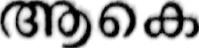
ആകെ
